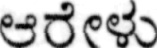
ಆರೇಳು
